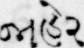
જાહેર
